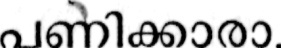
പണിക്കാരാ.
